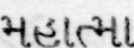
મહાત્મા
